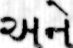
અને
